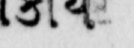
શકાય
